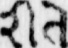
રીતે
